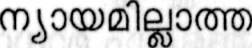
ന്യായമില്ലാത്ത
